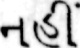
નહીં
